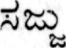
ಸಜ್ಜು
